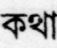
কথা
